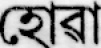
হোৱা
